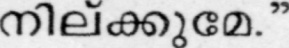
നില്ക്കുമേ.''
